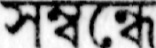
সম্বন্ধে
